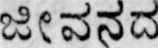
ಜೀವನದ
